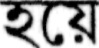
হয়ে
